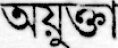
অয়ু্ক্তা
